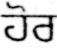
ਹੋਰ
